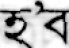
হ'ব
